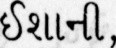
ઈશાની,
